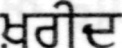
ਖ਼ਰੀਦ
